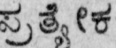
ಪ್ರತ್ಯೇಕ
